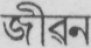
জীৱন
